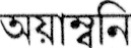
অয়াম্বনি
